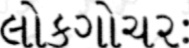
લોકગોચકઃ
